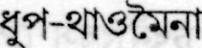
ধুপ-থাওমৈনা
